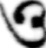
ও
